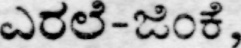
ಎರಲೆ-ಜಿಂಕೆ,
